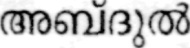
അബ്ദുല്‍
